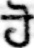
ਹੋ
